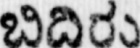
ಬಿದಿರು
